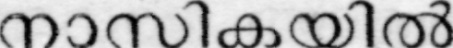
നാസികയില്‍
